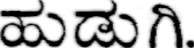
ಹುಡುಗಿ.
